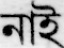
নাই
